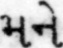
મને
